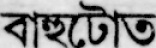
বাহুটোত
